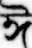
ঈ
